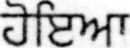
ਹੋਇਆ
